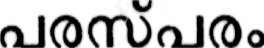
പരസ്പരം
